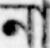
না
